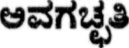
ಅವಗಚ್ಛತಿ
